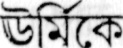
ঊর্মিকে
